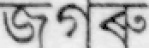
জগৰু
